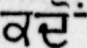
ਕਦੋਂ
